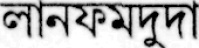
লানফমদুদা
